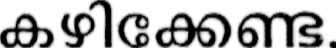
കഴിക്കേണ്ട.
